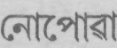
নোপোৱা
